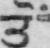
ਤੋਂ
